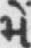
મેં
